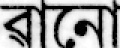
ৱানো
